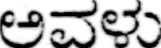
ಅವಳು
